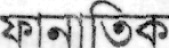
ফান্যতিক
